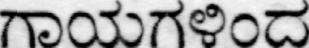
ಗಾಯಗಳಿಂದ
